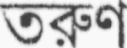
তরুণ
